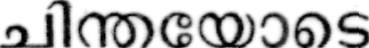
ചിന്തയോടെ
